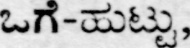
ಒಗೆ-ಹುಟ್ಟು,
